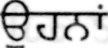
ਉਹਨਾਂ
